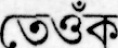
তেওঁক
